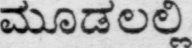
ಮೂಡಲಲ್ಲಿ
